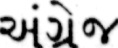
અંગ્રેજ
